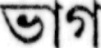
ভাগ
